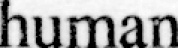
human
